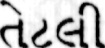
તેટલી
